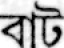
বাট
